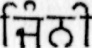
ਜਿੰਨੀ
